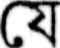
যে
